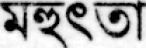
মহুৎতা
